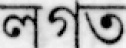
লগত
